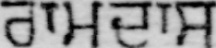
ਰਾਮਦਾਸ
